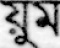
য়ুম
